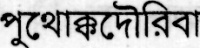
পুথোক্কদৌরিবা
